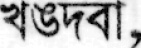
খঙদবা,
